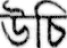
উচি
